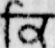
ਕਿ
